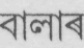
বালাৰ
